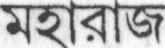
মহারাজ
